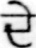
ਦੇ
